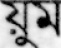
য়ুম
